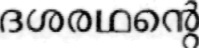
ദശരഥന്റെ
